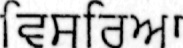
ਵਿਸਰਿਆ
